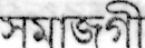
সমাজগী
